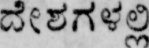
ದೇಶಗಳಲ್ಲಿ
